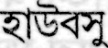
হাউবসু
